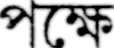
পক্ষে
